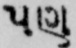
પણ
